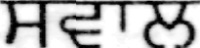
ਸਵਾਲ
